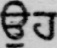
ਉਹ
